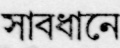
সাবধানে
